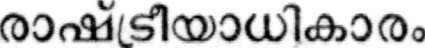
രാഷ്ട്രീയാധികാരം
